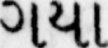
ગયા
